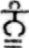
ਨੂੰ
